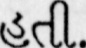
હતી.
